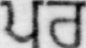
ਪਰ
